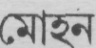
মোহন
